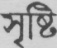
সৃষ্টি
